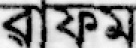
ৱাফম
